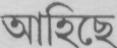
আহিছে
